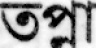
তপ্না
